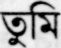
তুমি
